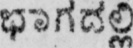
ಭಾಗದಲ್ಲಿ
